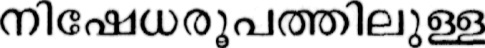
നിഷേധരൂപത്തിലുള്ള
